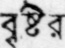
বৃষ্টির
